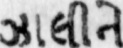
ઝાલીને
